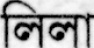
লিলা
